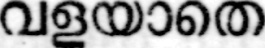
വളയാതെ
